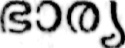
ഭാര്യ
